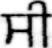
ਸੀ
